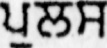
ਪੁਲਸ
